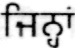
ਜਿਨ੍ਹਾਂ
